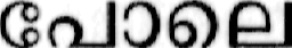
പോലെ
